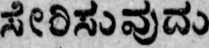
ಸೇರಿಸುವುದು
